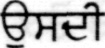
ਉਸਦੀ
